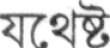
যথেষ্ট
